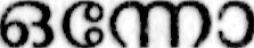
ഒന്നോ
